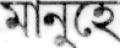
মানুহে
